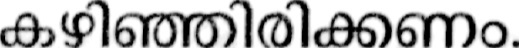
കഴിഞ്ഞിരിക്കണം.
